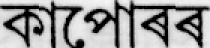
কাপোৰৰ
